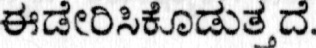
ಈಡೇರಿಸಿಕೊಡುತ್ತದೆ.
